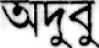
অদুবু
